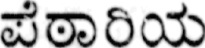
ಪೆಠಾರಿಯ
